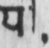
ਧਾਂ,
